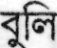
বুলি
